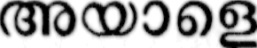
അയാളെ
